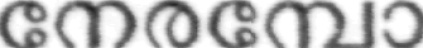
നേരമ്പോ
